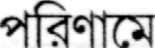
পরিণামে
